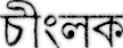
চীংলক
